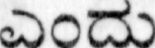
ಎಂದು
